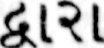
દ્વારા
